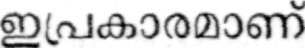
ഇപ്രകാരമാണ്
